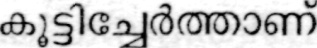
കൂട്ടിച്ചേര്‍ത്താണ്
